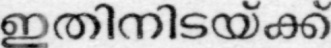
ഇതിനിടയ്ക്ക്
